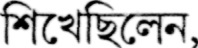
শিখেছিলেন,
